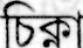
চিক্না
